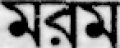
মরম
